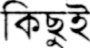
কিছুই
